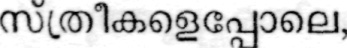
സ്ത്രീകളെപ്പോലെ,
